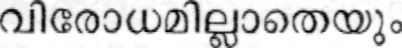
വിരോധമില്ലാതെയും
